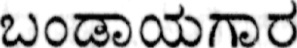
ಬಂಡಾಯಗಾರ
